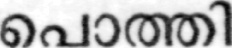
പൊത്തി
